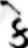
કે
